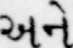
અને
